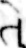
તે
